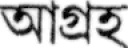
আগ্রহ
